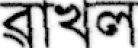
ৱাখল
